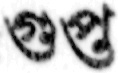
গুপ্ত
